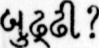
બુઢ્ઢી?
